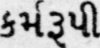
કર્મરૂપી
